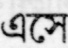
এসে
